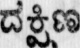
ದಕ್ಷಿಣ
